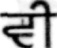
ਵੀ
